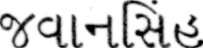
જવાનસિંહ
